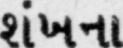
શંખના
